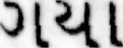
ગયા
